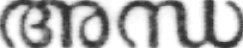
അന്ധ
